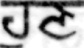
ਹੁਣ
